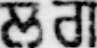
ਲਗ
